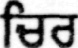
ਚਿਰ
